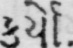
કર્યો.
